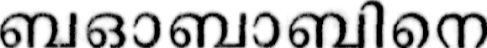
ബഓബാബിനെ
